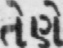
તેણે
